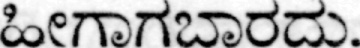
ಹೀಗಾಗಬಾರದು.
